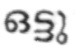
ഒട്ടു
